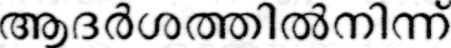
ആദര്‍ശത്തില്‍നിന്ന്
